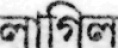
লাগিল
